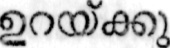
ഉറയ്ക്കു
